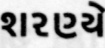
શરણ્યે
